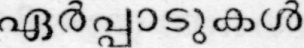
ഏര്‍പ്പാടുകള്‍
